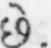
છે.
